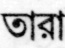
তারা
